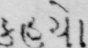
કહ્યો
